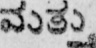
ಮತ್ತು
